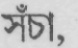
সঁচা,
